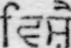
ਵਿਸ਼ੈ
